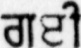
ਗਈ
